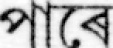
পাৰে
